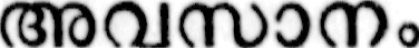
അവസാനം
